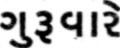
ગુરૂવારે
